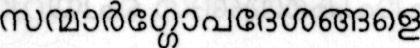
സന്മാര്‍ഗ്ഗോപദേശങ്ങളെ
